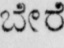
ಬೇರೆ
